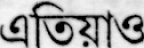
এতিয়াও
